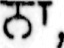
ਨਾ,
